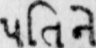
પતિને
